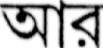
আর
